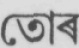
তোৰ
